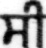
ਸੀ
